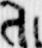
તો
